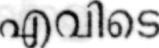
എവിടെ
